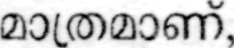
മാത്രമാണ്,
